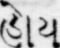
હોય
